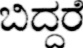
ಬಿದ್ದರೆ
